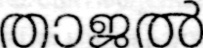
താജല്‍
